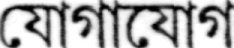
যোগাযোগ
